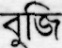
বুজি
